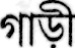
গাড়ী
